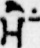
ਮੈਂ
